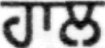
ਹਾਲ
